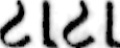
ટાટા
